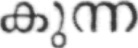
കുന്ന
